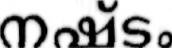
നഷ്ടം
